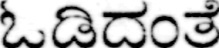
ಓಡಿದಂತೆ
